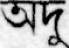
অদু
